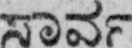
ಸಾರ್ವ
